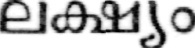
ലക്ഷ്യം
